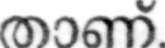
താണ്.
